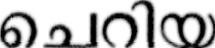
ചെറിയ
